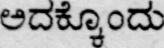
ಅದಕ್ಕೊಂದು
